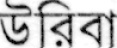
উরিবা
